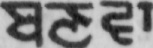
ਬਣਵਾ
